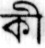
কী
